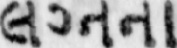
લગ્નના
